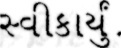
સ્વીકાર્યું.
